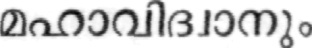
മഹാവിദ്വാനും
